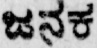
ಜನಕ
